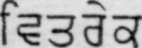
ਵਿਤਰੇਕ
